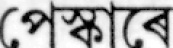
পেস্কাৰে
